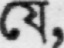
যে,
